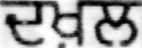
ਦਖ਼ਲ
